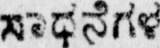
ಸಾಧನೆಗ
